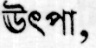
ঊৎপা,
